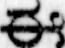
ಈ
